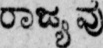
ರಾಜ್ಯವು
